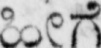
ಹೀಗೆ
